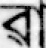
ৱা
